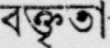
বক্তৃতা
